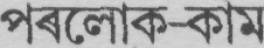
পৰলোক-কাম
